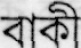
বাকী
